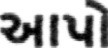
આપો
